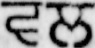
ਵਲ
